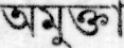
অমুক্তা
